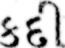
કદી
